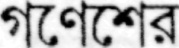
গণেশের
